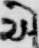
એ
